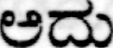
ಅದು
